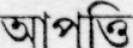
আপত্তি
